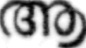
ആ
